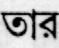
তার
